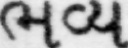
ભવ્ય
